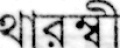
থারম্মী
